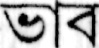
ভাব
